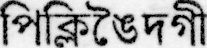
পিক্লিঙৈদগী
